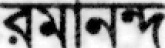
রমানন্দ
